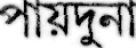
পায়দুনা
